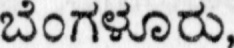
ಬೆಂಗಳೂರು,
